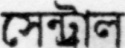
সেন্ট্রাল
